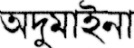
অদুমাইনা
